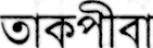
তাকপীবা
